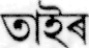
তাইৰ
